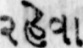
રહેવા
